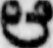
ಆ
